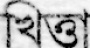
খিত্তা
